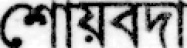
শোয়বদা
